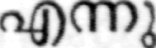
എന്നു
